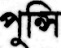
পুন্সি
